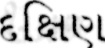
દક્ષિણ
